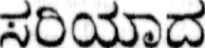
ಸರಿಯಾದ
